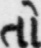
તો
